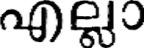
എല്ലാ
